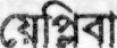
য়েপ্লিবা
